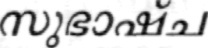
സുഭാഷ്ച
